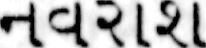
નવરાશ
